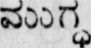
ಮುಗ್ಧ
